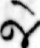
જે
